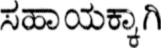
ಸಹಾಯಕ್ಕಾಗಿ
